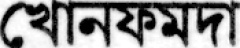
খোনফমদা
